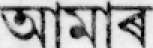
আমাৰ
